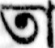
তা
